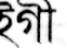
ইগী
